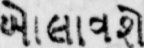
બોલાવશે
